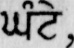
ਘੰਟੇ,
